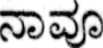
ನಾವೂ
